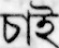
চাই
